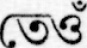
তেওঁ
